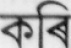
কৰি
